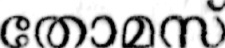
തോമസ്
